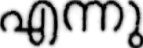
എന്നു
